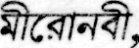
মীরোনবী,
